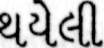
થયેલી
